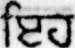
ਇਹ
